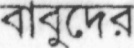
বাবুদের
